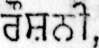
ਰੌਸ਼ਨੀ,
